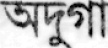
অদুগা
